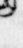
છે
